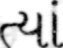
ત્યાં
